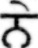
ਨੇ
